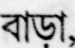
বাড়া,
